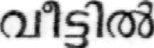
വീട്ടില്‍
